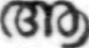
ആ
